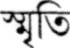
স্মৃতি
